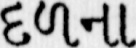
દળના
